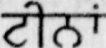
ਟੀਨਾਂ
